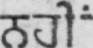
ਨਹੀਂ
